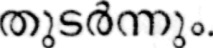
തുടര്‍ന്നും.
